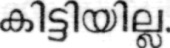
കിട്ടിയില്ല.
